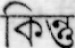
কিন্তু
